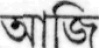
আজি
